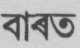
বাৰত
